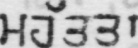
ਮਹੱਤਤਾ
